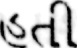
હતી
